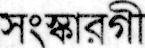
সংস্কারগী
